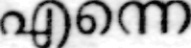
എന്നെ
